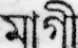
মাগী
